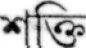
শক্তি
